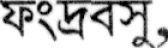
ফংদ্রবসু,
